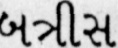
બત્રીસ
